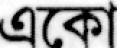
একো
